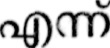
എന്ന്
